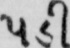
પડી
